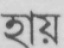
হায়
